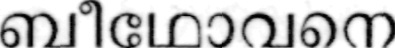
ബീഥോവനെ
